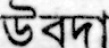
উবদা
